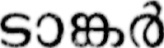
ടാങ്കര്‍
